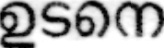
ഉടനെ
